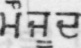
ਮੌਜੂਦ
